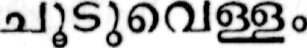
ചൂടുവെള്ളം
